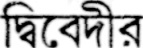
দ্বিবেদীর
